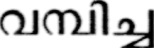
വമ്പിച്ച
